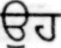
ਉਹ
